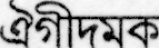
ঐগীদমক
